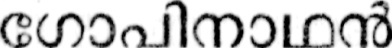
ഗോപിനാഥന്‍
